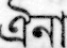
ঐনা
